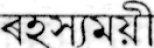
ৰহস্যময়ী
